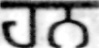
ਹਨ
